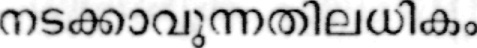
നടക്കാവുന്നതിലധികം
